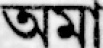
অমা
